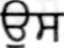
ਉਸ
